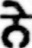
ਨੇ
